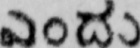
ಎಂದು
